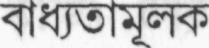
বাধ্যতামূলক
